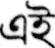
এই
